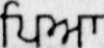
ਪਿਆ
